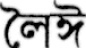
লৈঈ
